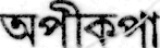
অপীকপা
